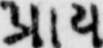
પ્રાય
